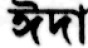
ঈদা
